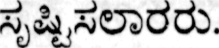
ಸೃಷ್ಟಿಸಲಾರರು.
